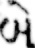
બે
